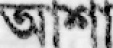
আশা
